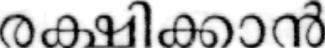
രക്ഷിക്കാന്‍
